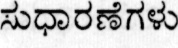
ಸುಧಾರಣೆಗಳು
